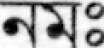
নমঃ
